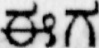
ಈಗ
